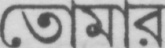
তোমার
